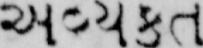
અવ્યક્ત
